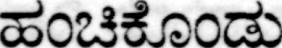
ಹಂಚಿಕೊಂಡು
